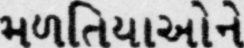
મળતિયાઓને
